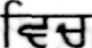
ਵਿਚ
